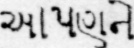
આપણને
